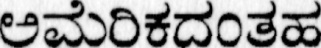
ಅಮೆರಿಕದಂತಹ
